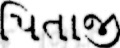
પિતાજી
